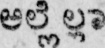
ಅಲ್ಲೆಲ್ಲಾ
